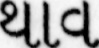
થાવ
